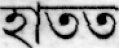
হাতত
